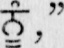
ਨੂੰ,''
